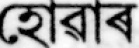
হোৱাৰ
